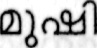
മുഷി
